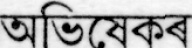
অভিষেকৰ
